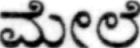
ಮೇಲೆ
